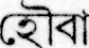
হৌবা
